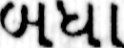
બધા
